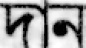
দান
